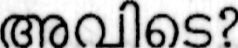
അവിടെ?
